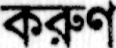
করুণ
